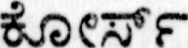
ಕೋರ್ಸ್
